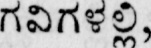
ಗವಿಗಳಲ್ಲಿ,
